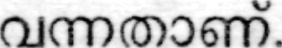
വന്നതാണ്.
